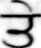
ਤੇ
